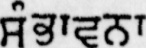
ਸੰਭਾਵਨਾ
